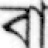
বা
